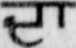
ਦਾ
